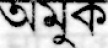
অমুক
